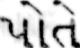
પોતે
